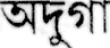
অদুগা
